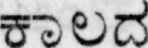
ಕಾಲದ
